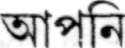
আপনি
